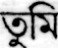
তুমি
